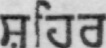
ਸ਼ਹਿਰ
